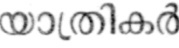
യാത്രികര്‍
